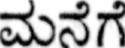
ಮನೆಗೆ
